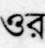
ওর
